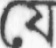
যে
